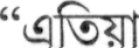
"এতিয়া
